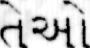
તેઓ
